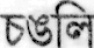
চঙলি
